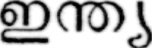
ഇന്ത്യ
